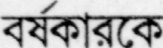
বর্ষকারকে
